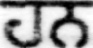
ਹਨ
